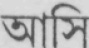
আসি
